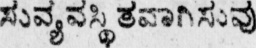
ಸುವ್ಯವಸ್ಥಿತವಾಗಿಸುವು
